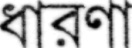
ধারণা
